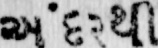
અંદરથી
